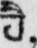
ਹੈ,
